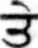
ਤੇ
